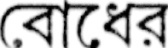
বোধের
